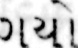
ગયો
